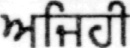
ਅਜਿਹੀ
